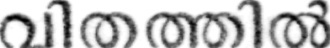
വിതത്തില്‍
